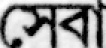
সেবা
